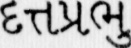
દત્તપ્રભુ
